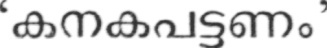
'കനകപട്ടണം'
